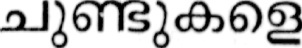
ചുണ്ടുകളെ
